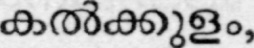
കല്‍ക്കുളം,
